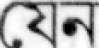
যেন
